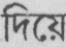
দিয়ে
